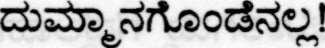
ದುಮ್ಮಾನಗೊಂಡೆನಲ್ಲ!
